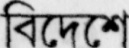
বিদেশে
